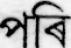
পৰি
